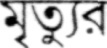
মৃত্যুর
